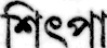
শিৎপা
